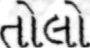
તોલો
